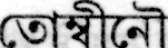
তোম্বীনৌ
